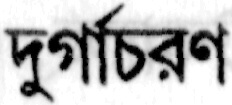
দুর্গাচরণ
